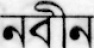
নবীন
